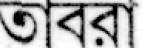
তাবরা
